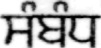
ਸੰਬੰਧ
